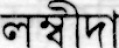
লম্বীদা
